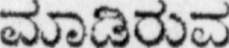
ಮಾಡಿರುವ
